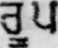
ਰੂਪ
